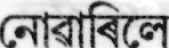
নোৱাৰিলে
